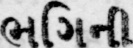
ભગિની
